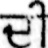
ਦੀ
